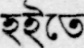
হইতে
